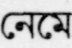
নেমে
